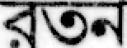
রতন
